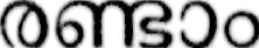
രണ്ടാം
